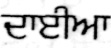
ਦਾਈਆ
